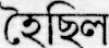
হৈছিল
